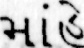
માંહે
